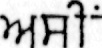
ਅਸੀਂ
